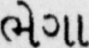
ભેગા
